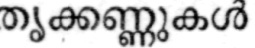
തൃക്കണ്ണുകള്‍
